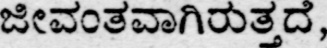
ಜೀವಂತವಾಗಿರುತ್ತದೆ,
